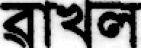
ৱাখল
